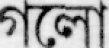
গলো
